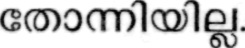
തോന്നിയില്ല.
